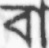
বা
